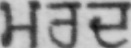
ਮਰਦ
